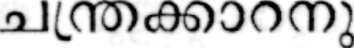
ചന്ത്രക്കാറനു
